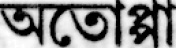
অতোপ্পা
